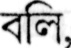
বলি,
